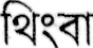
থিংবা
